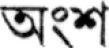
অংশ
